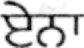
ਏਨਾ
